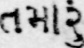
તમારું
